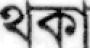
থকা
